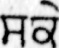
ਸਕੇ
